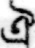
ঐ
